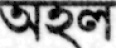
অহল
